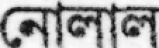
নোলাল
